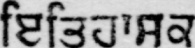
ਇਤਿਹਾਸਕ
